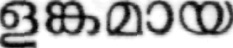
ളങ്കമായ
